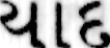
યાદ
